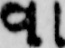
વા
